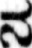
ನ
